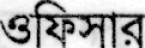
ওফিসার
